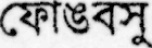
ফোঙবসু
